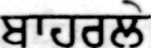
ਬਾਹਰਲੇ
